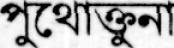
পুথোক্তুনা
